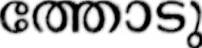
ത്തോടു
